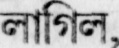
লাগিল,
